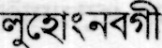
লুহোংনবগী
